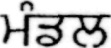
ਮੰਡਲ
